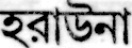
হরাউনা
